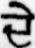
ਦੇ
